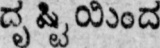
ದೃಷ್ಟಿಯಿಂದ
